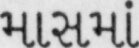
માસમાં
